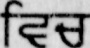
ਵਿਚ
